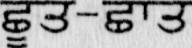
ਛੂਤ-ਛਾਤ
